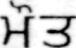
ਮੌਤ
